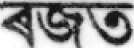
ৰজত
